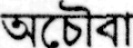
অচৌবা
